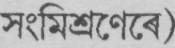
সংমিশ্ৰণেৰে)
